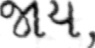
જાય,
